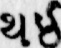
થઈ
